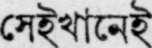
সেইখানেই
